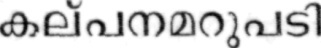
കല്പനമറുപടി
